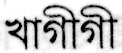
খাগীগী
